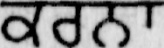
ਕਰਨਾ
